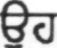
ਉਹ
